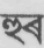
হুৰ
